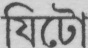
যিটো
